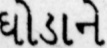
ઘોડાને
